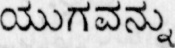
ಯುಗವನ್ನು
